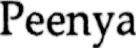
Peenya
